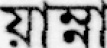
য়াম্না
